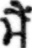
ਮੈਂ
